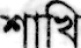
শাখি
